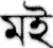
মই
